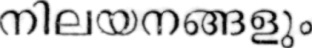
നിലയനങ്ങളും
